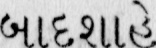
બાદશાહે
